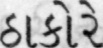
ઠાકોરે
